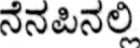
ನೆನಪಿನಲ್ಲಿ
